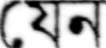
যেন
